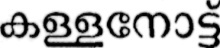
കള്ളനോട്ട്
